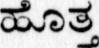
ಹೊತ್ತ
